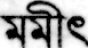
মমীৎ
